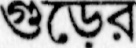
গুড়ের
